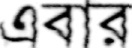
এবার
